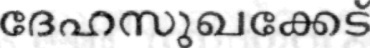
ദേഹസുഖക്കേട്
